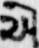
એ
